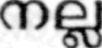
നല്ല
